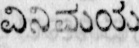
ವಿನಿಮಯ
